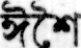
ঈশৈ
